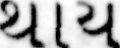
થાય
